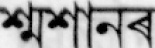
শ্মশানৰ
